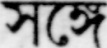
সঙ্গে
